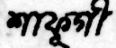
শাফূগী
